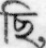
ছি,
